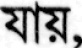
যায়,
